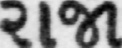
રાજા
